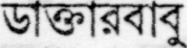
ডাক্তারবাবু
